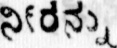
ನೀರನ್ನು
